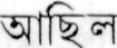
আছিল
